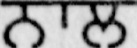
ਨਾਲ
